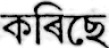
কৰিছে
